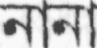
নানা
